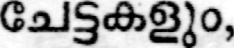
ചേട്ടകളും,
